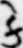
કે
